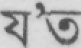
য'ত
